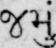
જમું
